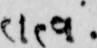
તત્વં.
